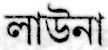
লাউনা
